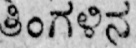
ತಿಂಗಳಿನ
